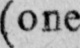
(one
